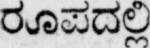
ರೂಪದಲ್ಲಿ
